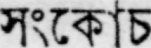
সংকোচ
